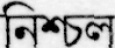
নিশ্চল
